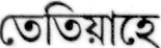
তেতিয়াহে
